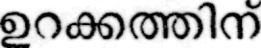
ഉറക്കത്തിന്
